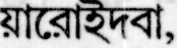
য়ারোইদবা,
